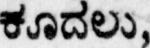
ಕೂದಲು,
